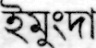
ইমুংদা
